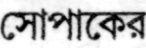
সোপাকের
